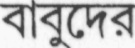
বাবুদের
